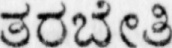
ತರಬೇತಿ
